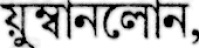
য়ুম্বানলোন,
